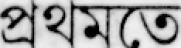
প্রথমতে
